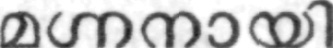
മഗ്നനായി
